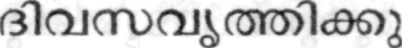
ദിവസവൃത്തിക്കു
